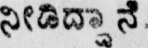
ನೀಡಿದ್ದಾನೆ.
